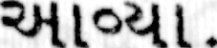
આવ્યા.
